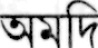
অমদি
